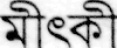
মীৎকী
